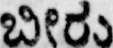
ಬೀರು
